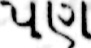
પણ
